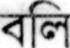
বলি
